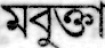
মবুক্তা
